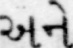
અને
